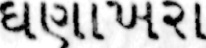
ઘણાખરા
